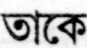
তাকে
